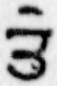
ਤੇ
